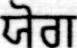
ਯੋਗ
